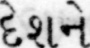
દેશને
